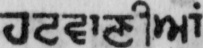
ਹਟਵਾਣੀਆਂ
